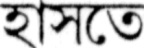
হাসতে
